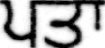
ਪਤਾ
